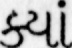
ક્યાં
